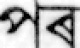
পৰ
